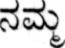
ನಮ್ಮ
